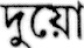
দুয়ো
